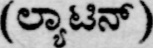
(ಲ್ಯಾಟಿನ್)
